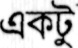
একটু
